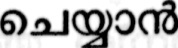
ചെയ്യാന്‍
